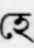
হে
